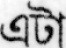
এটা
